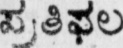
ಪ್ರತಿಫಲ
